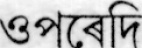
ওপৰেদি
